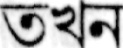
তখন
